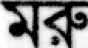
মরু
